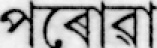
পৰোৱা
